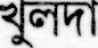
খুলদা
